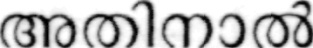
അതിനാല്‍
